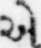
એ
